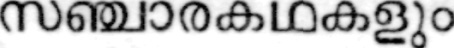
സഞ്ചാരകഥകളും
